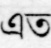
এত
